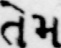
તેમ
